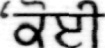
'ਕੋਈ
